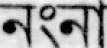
নংনা
